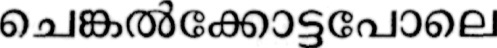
ചെങ്കല്‍ക്കോട്ടപോലെ
